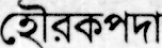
হৌরকপদা
